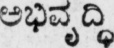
ಅಭಿವೃದ್ಧಿ
